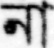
না
